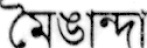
মৈঙান্দা
